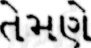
તેમણે
